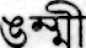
ঙম্মী
